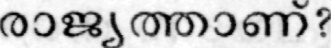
രാജ്യത്താണ്?
